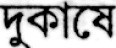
দুকাষে
